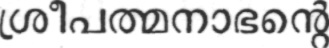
ശ്രീപത്മനാഭന്റെ
